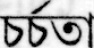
চর্চতা
